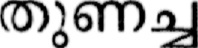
തുണച്ച
